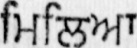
ਮਿਲਿਆ
